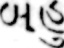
બહુ
